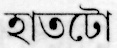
হাতটো
